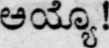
ಅಯ್ಯೊ!
